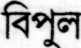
বিপুল
